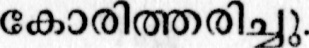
കോരിത്തരിച്ചു.
